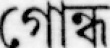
গোন্ধ
